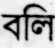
বলি
